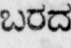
ಬರದ
